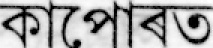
কাপোৰত
